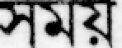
সময়
